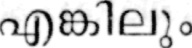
എങ്കിലും
